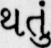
થતું
